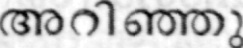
അറിഞ്ഞു
